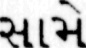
સામે
